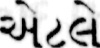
એટલે
